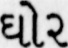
ઘોર
